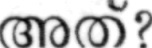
അത്?
